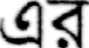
এর
